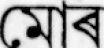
মোৰ
